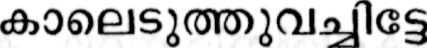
കാലെടുത്തുവച്ചിട്ടേ
